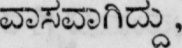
ವಾಸವಾಗಿದ್ದು,
